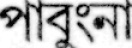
পাবুংনা
